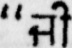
''ਜੀ
